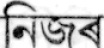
নিজৰ
